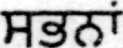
ਸਭਨਾਂ
